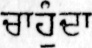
ਚਾਹੁੰਦਾ
